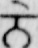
ਨੇ
